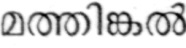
മത്തിങ്കല്‍
